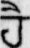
ਹੈ
